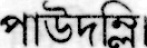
পাউদম্নি।
